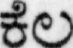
ಕೆಲ
